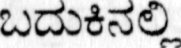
ಬದುಕಿನಲ್ಲಿ
